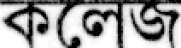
কলেজ
